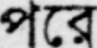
পরে
